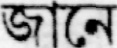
জানে
